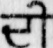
ਦੀ
